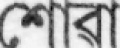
শোৱা
